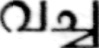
വച്ച
